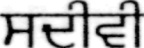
ਸਦੀਵੀ
